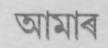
আমাৰ
